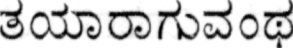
ತಯಾರಾಗುವಂಥ
